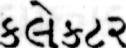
કલેક્ટર
